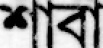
শাবা
